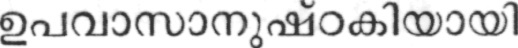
ഉപവാസാനുഷ്ഠകിയായി
